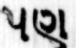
પણ
